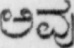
ಅವು
